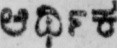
ಆರ್ಥಿಕ
